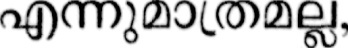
എന്നുമാത്രമല്ല,
